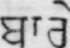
ਬਾਰੇ
